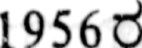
1956ರ
